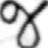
જ
